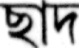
ছাদ
